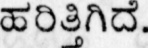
ಹರಿತ್ತಿಗಿದೆ.
